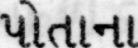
પોતાના
